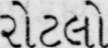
રોટલો
